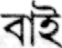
বাই
